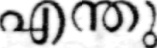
എന്തു
